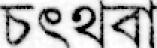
চৎথবা
